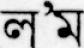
ল'ম
